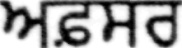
ਅਫ਼ਸਰ
